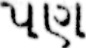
પણ
